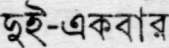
দুই-একবার
